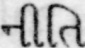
નીતિ
